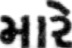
મારે
